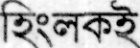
হিংলকই
